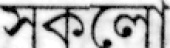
সকলো
